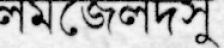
লমজেলদসু
